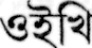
ওইখি
